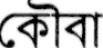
কৌবা
